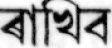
ৰাখিব
